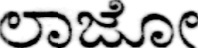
ಲಾಜೋ
